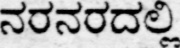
ನರನರದಲ್ಲಿ
